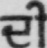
ਦੀ
